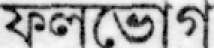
ফলভোগ
